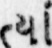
ત્યાં
